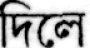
দিলে
